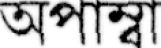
অপাম্বা
